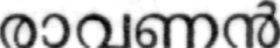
രാവണന്‍
